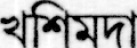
খশিমদা
